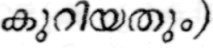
കുറിയതും)
